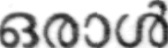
ഒരാള്‍
